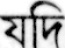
যদি
